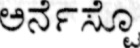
ಅರ್ನೆಸ್ಟೊ
